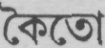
কৈতো
